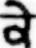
ਕੇ
